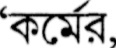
'কর্মের,
